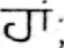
ਹਾਂ;
